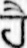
ਹੈ
